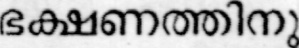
ഭക്ഷണത്തിനു
